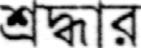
শ্রদ্ধার
